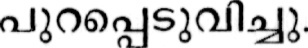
പുറപ്പെടുവിച്ചു.
